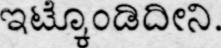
ಇಟ್ಕೊಂಡಿದೀನಿ.
